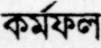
কর্মফল
